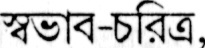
স্বভাব-চরিত্র,
